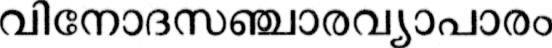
വിനോദസഞ്ചാരവ്യാപാരം
